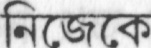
নিজেকে
